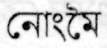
নোংমৈ
